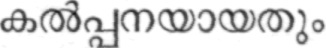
കല്‍പ്പനയായതും
